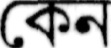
কেন
